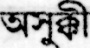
অসুক্কী
